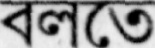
বলতে
